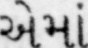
એમાં
